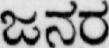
ಜನರ
